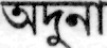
অদুনা
